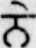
ਨੇ
